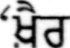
'ਖ਼ੈਰ
